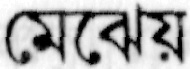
মেঝেয়
